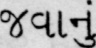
જવાનું
